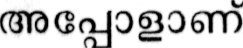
അപ്പോളാണ്
